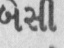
બેસી
